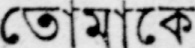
তোমাকে
